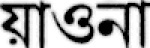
য়াওনা
